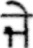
ਜੇ
